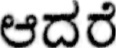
ಆದರೆ
